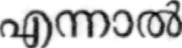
എന്നാല്‍
